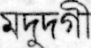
মদুদগী
